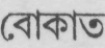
বোকাত
